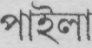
পাইলা
